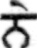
ਨੇ
